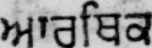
ਆਰਥਿਕ
